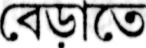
বেড়াতে
